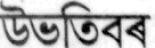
উভতিবৰ
